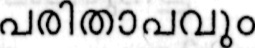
പരിതാപവും
